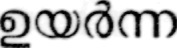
ഉയര്‍ന്ന
